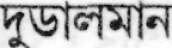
দুডালমান
